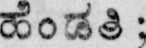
ಹೆಂಡತಿ;
